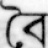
বৈ
